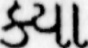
ક્યા
